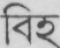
বিহ
